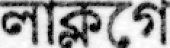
লাক্লগে
